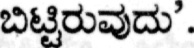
ಬಿಟ್ಟಿರುವುದು’,
